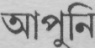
আপুনি
